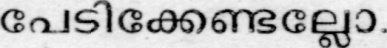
പേടിക്കേണ്ടല്ലോ.
